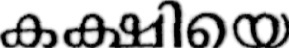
കക്ഷിയെ
